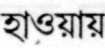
হাওয়ায়
